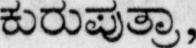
ಕುರುಪುತ್ರಾ,
